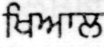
ਖਿਆਲ
